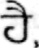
ਹੈ,
